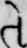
તે
